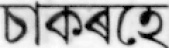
চাকৰহে
